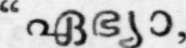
"ഏഭ്യാ,
